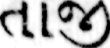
તાજી
